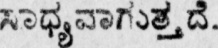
ಸಾಧ್ಯವಾಗುತ್ತದೆ.
